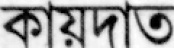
কায়দাত
